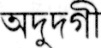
অদুদগী
